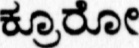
ಕ್ರೂರೋ
